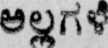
ಅಲ್ಲಗಳೆ
